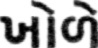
ખોળે
